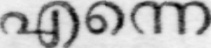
എന്നെ
